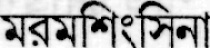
মরমশিংসিনা
